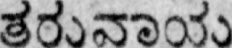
ತರುವಾಯ
